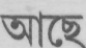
আছে
